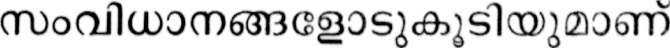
സംവിധാനങ്ങളോടുകൂടിയുമാണ്
